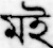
মই
